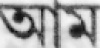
আম
